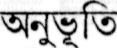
অনুভূতি
